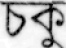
চকু
